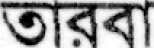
তারবা
